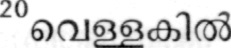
20വെള്ളകില്‍
